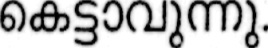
കെട്ടാവുന്നു.
